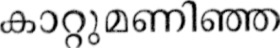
കാറ്റുമണിഞ്ഞ
